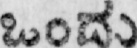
ಒಂದು
